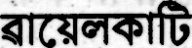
ৱায়েলকাটি
